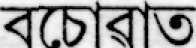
বচোৱাত
